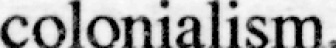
colonialism.
